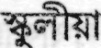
স্কুলীয়া
